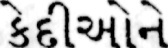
કેદીઓને
